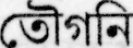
তৌগনি
